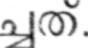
ച്ചത്.
